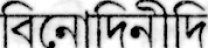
বিনোদিনীদি
